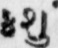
કશું
